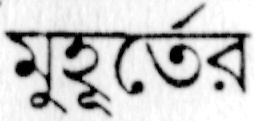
মুহূর্তের
